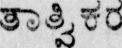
ತಾತ್ವಿಕರ
